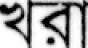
খরা
